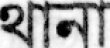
থানা
